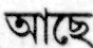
আছে
